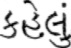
કહેલું
